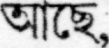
আছে,
